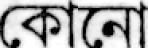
কোনো
